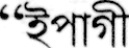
“ইপাগী
